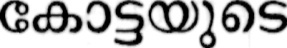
കോട്ടയുടെ
